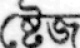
ষ্টেজ
